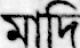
মাদি
